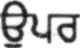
ਉਪਰ
